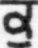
ਕੁ
